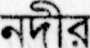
নদীর
